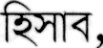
হিসাব,
